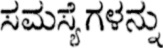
ಸಮಸ್ಯೆಗಳನ್ನು
